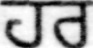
ਹਰ
